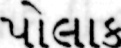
પોલાક
